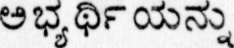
ಅಭ್ಯರ್ಥಿಯನ್ನು
